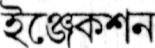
ইঞ্জেকশন
